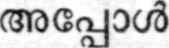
അപ്പോള്‍
